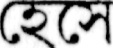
হেসে
